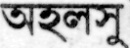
অহনসু
